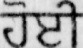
ਹੋਈ
